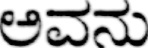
ಅವನು
